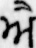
ਐ
